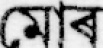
মোৰ
